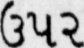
ઉપર
